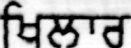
ਖਿਲਾਰ
